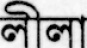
লীলা
